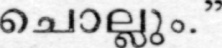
ചൊല്ലും."
